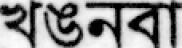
খঙনবা
